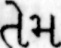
તેમ
